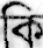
কি
